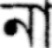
না
